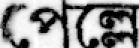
পেল্লে
